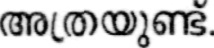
അത്രയുണ്ട്.
